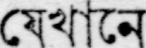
যেখানে
